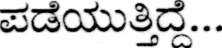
ಪಡೆಯುತ್ತಿದ್ದೆ...
